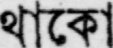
থাকো
